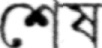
শেষ
